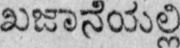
ಖಜಾನೆಯಲ್ಲಿ
